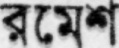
রমেশ
